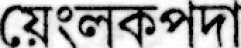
য়েংলকপদা
